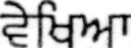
ਵੇਖਿਆ
